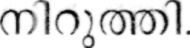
നിറുത്തി.
